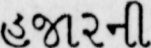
હજારની
